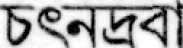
চৎনদ্রবা
